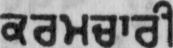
ਕਰਮਚਾਰੀ
